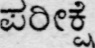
ಪರೀಕ್ಷೆ
